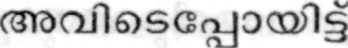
അവിടെപ്പോയിട്ട്
